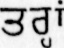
ਤਰ੍ਹਾਂ
